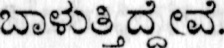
ಬಾಳುತ್ತಿದ್ದೇವೆ.
